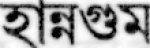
হান্নগুম
